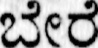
ಬೇರೆ
